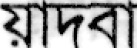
য়াদবা
